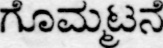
ಗೊಮ್ಮಟನೆ
